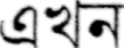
এখন
